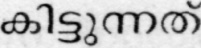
കിട്ടുന്നത്
